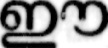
ഈ
